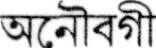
অনৌবগী
